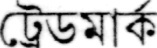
ট্রেডমার্ক
